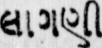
લાગણી
